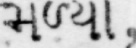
મળ્યા,
